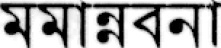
মমান্নবনা
